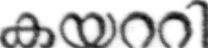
കയററി
